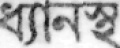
ধ্যানস্থ
